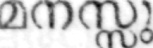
മനസ്സു
